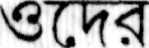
ওদের
